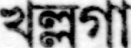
খল্লগা
